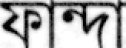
ফান্দা
